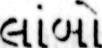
લાંબો
